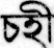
চহী
